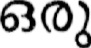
ഒരു
